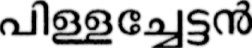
പിള്ളച്ചേട്ടന്‍
